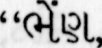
"ભેંણ,
